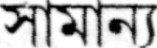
সামান্য
